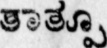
ತಾತ್ಪೂ
